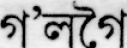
গ'লগৈ
